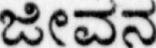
ಜೀವನ
